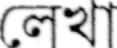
লেখা
